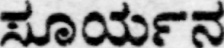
ಸೂರ್ಯನ
